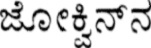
ಜೋಕ್ವಿನ್ನ
